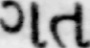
ગત
